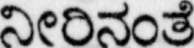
ನೀರಿನಂತೆ
